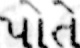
પોતે
